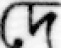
দে
